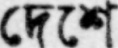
দেশে
